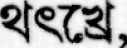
থৎখ্রে,
